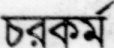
চরকর্ম
